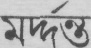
মৰ্দ্দন্ত
